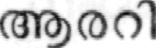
ആരറി
